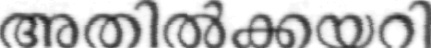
അതില്‍ക്കയറി
